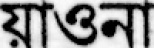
য়াওনা
